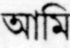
আমি
